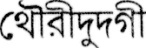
থৌরীদুদগী
